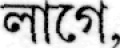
লাগে,
